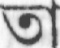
তা
